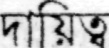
দায়িত্ব
